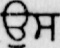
ਉਸ
